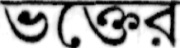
ভক্তের
